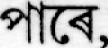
পাৰে,
